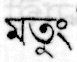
মতুং
